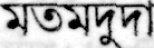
মতমদুদা
